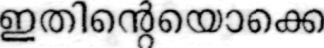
ഇതിന്റെയൊക്കെ
